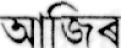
আজিৰ
